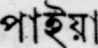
পাইয়া
